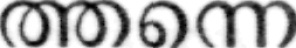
ത്തന്നെ
